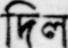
দিল
